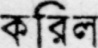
করিল
